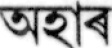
অহাৰ
